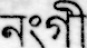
নংগী
